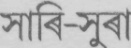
সাৰি-সুৰা
